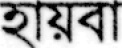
হায়বা
